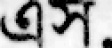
এস.
